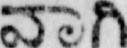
ವಾಗಿ
